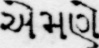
એમણે
